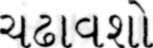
ચઢાવશો
